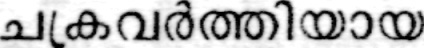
ചക്രവര്‍ത്തിയായ
